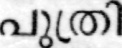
പുത്രി
